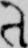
તે
